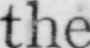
the
